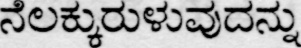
ನೆಲಕ್ಕುರುಳುವುದನ್ನು
